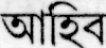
আহিব
